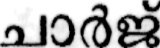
ചാര്‍ജ്
